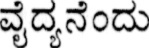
ವೈದ್ಯನೆಂದು
